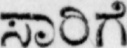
ಸಾರಿಗೆ
